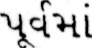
પૂર્વમાં
